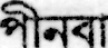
পীনবা
